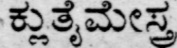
ಕ್ಲುತೈಮೇಸ್ತ್ರ
